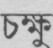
চক্ষু
